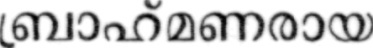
ബ്രാഹ്മണരായ
